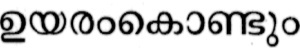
ഉയരംകൊണ്ടും
